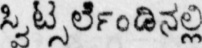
ಸ್ವಿಟ್ಸರ್ಲೆಂಡಿನಲ್ಲಿ
